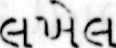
લખેલ
